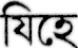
যিহে
